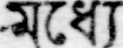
মধ্যে
